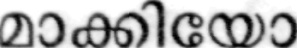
മാക്കിയോ
